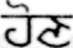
ਹੋਣ
